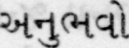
અનુભવો
